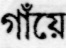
গাঁয়ে
